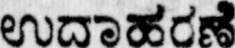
ಉದಾಹರಣೆ
